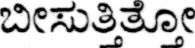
ಬೀಸುತ್ತಿತ್ತೋ
